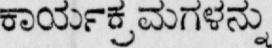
ಕಾರ್ಯಕ್ರಮಗಳನ್ನು
